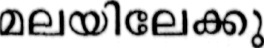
മലയിലേക്കു
